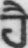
ਹੈ
